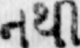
નથી
